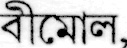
বীমোল,
